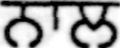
ਨਾਲ
